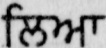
ਲਿਆ
